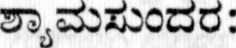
ಶ್ಯಾಮಸುಂದರ:
